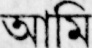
আমি
